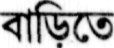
বাড়িতে
